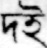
দই
